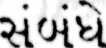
સંબંધે
